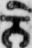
ਨੇ
